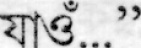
যাওঁ..."
